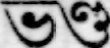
ভণ্ড
